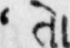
'તો
